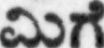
ಮಿಗೆ
